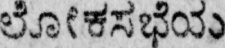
ಲೋಕಸಭೆಯ
